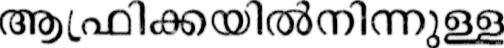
ആഫ്രിക്കയില്‍നിന്നുള്ള
